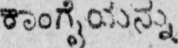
ಕಾಂಗೈಯನ್ನು
